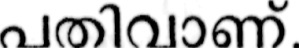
പതിവാണ്.
